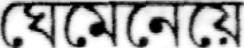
ঘেমেনেয়ে
